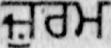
ਜ਼ੁਰਮ
